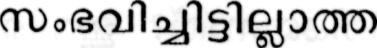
സംഭവിച്ചിട്ടില്ലാത്ത
